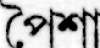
পৈশা
